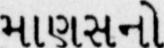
માણસનો
